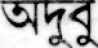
অদুবু
